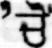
'ਚੋਂ
